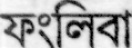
ফংলিবা
